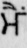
ਮੈਂ
